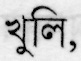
খুলি,
